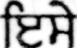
ਇਸੇ
